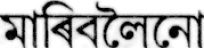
মাৰিবলৈনো
